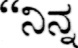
"ನಿನ್ನ
